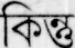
কিন্তু
